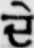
ਦੇ
